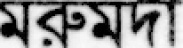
মরুমদা
